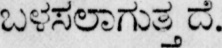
ಬಳಸಲಾಗುತ್ತದೆ.
